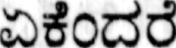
ಏಕೆಂದರೆ
